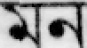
মন
